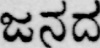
ಜನದ
